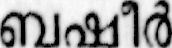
ബഷീര്‍
